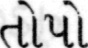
તોપો
